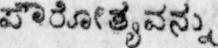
ಪೌರೋತ್ಯವನ್ನು
